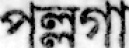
পল্লগা
